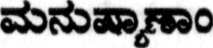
ಮನುಷ್ಯಾಣಾ೦
